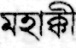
মহাক্কী
